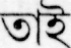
তাই
